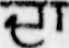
ਦਾ
